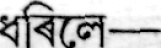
ধৰিলে-
